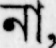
না,
